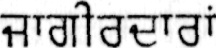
ਜਾਗੀਰਦਾਰਾਂ
